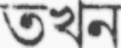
তখন
